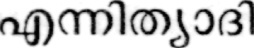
എന്നിത്യാദി
